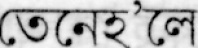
তেনেহ'লে
